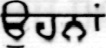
ਉਹਨਾਂ
